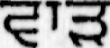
ਵਾੜ
